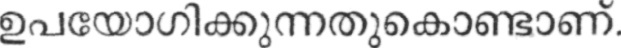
ഉപയോഗിക്കുന്നതുകൊണ്ടാണ്.
